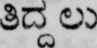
ತಿದ್ದಲು
